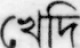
খেদি
